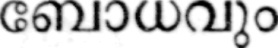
ബോധവും
